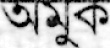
অমুক
